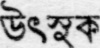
উৎসুক
